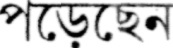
পড়েছেন
